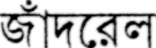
জাঁদরেল
